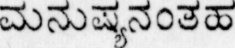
ಮನುಷ್ಯನಂತಹ
